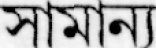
সামান্য
